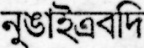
নুঙাইত্রবদি
